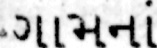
ગામનાં
